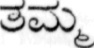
ತಮ್ಮ
